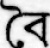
বৈ
